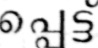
പ്പെട്ട്
